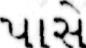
પાસે
